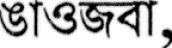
ঙাওজবা,
